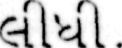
લીધી.
